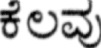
ಕೆಲವು
